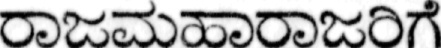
ರಾಜಮಹಾರಾಜರಿಗೆ
